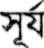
সূর্য
